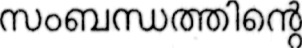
സംബന്ധത്തിന്റെ
